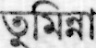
তুমিন্না
